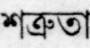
শত্রুতা
